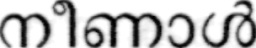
നീണാള്‍
